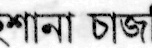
শানা চাজ
